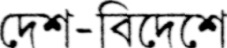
দেশ-বিদেশে
